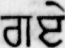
ਗਏ
